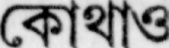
কোথাও
